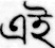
এই
